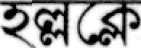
হল্লক্লে
